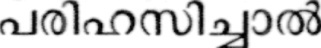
പരിഹസിച്ചാല്‍
